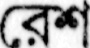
রেশ
